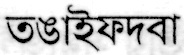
তঙাইফদবা
